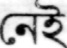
নেই
